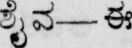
ಶೈವ-ಈ
